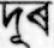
দূৰ
